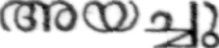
അയച്ചു
